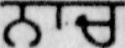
ਨਾਚ
